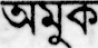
অমুক
